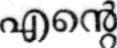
എന്റെ
